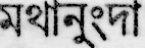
মথানুংদা
